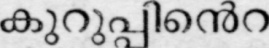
കുറുപ്പിന്റെ
